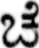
ಚೆ
